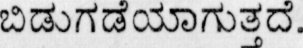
ಬಿಡುಗಡೆಯಾಗುತ್ತದೆ.
